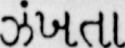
ઝંખતા
